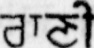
ਰਾਣੀ
